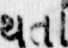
થતાં
